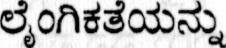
ಲೈಂಗಿಕತೆಯನ್ನು
